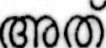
അത്
